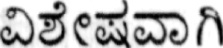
ವಿಶೇಷವಾಗಿ
